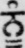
ਨੂੰ
